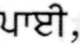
ਪਾਈ,
